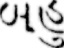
બહુ
